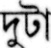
দুটা
